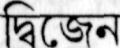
দ্বিজেন
